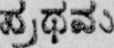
ಪ್ರಥಮ
